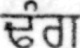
ਢੰਗ
